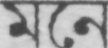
মনে
